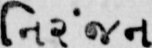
નિરંજન
